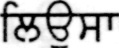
ਲਿਉਸਾ
